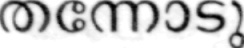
തന്നോടു
